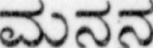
ಮನನ
